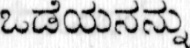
ಒಡೆಯನನ್ನು
